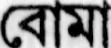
বোমা
